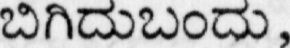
ಬಿಗಿದುಬಂದು,
